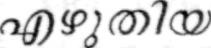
എഴുതിയ
